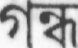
গন্ধ
